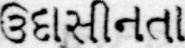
ઉદાસીનતા
